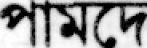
পামদে
